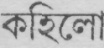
কহিলো
